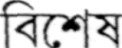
বিশেষ
